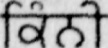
ਕਿੰਨੀ
